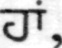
ਹਾਂ,
